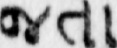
જતા
